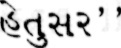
હેતુસર"
